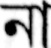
না
